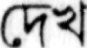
দেখ
